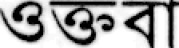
ওক্তবা
